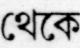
থেকে
